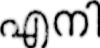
എനി
